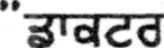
''ਡਾਕਟਰ
